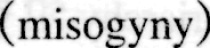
(misogyny)
